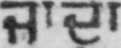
ਜਾਂਦਾ
